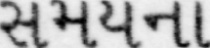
સમયના
